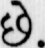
છે.
